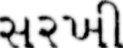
સરખી
